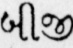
બીજી
